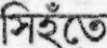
সিহঁতে
